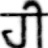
ਹੀ
